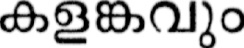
കളങ്കവും
